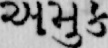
અમુક
